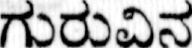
ಗುರುವಿನ
